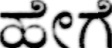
ಹೇಗೆ
